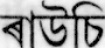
ৰাউচি
